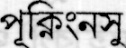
পূক্নিংনসু
